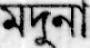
মদুনা
